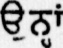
ਉਨ੍ਹਾਂ
